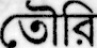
তৌরি
